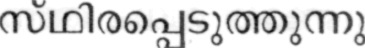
സ്ഥിരപ്പെടുത്തുന്നു
